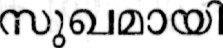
സുഖമായി
